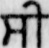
ਸੀ
